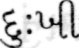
દુઃખી
